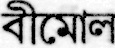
বীমোল
